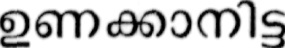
ഉണക്കാനിട്ട
